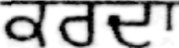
ਕਰਦਾ
